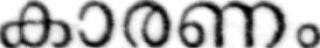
കാരണം
